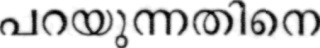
പറയുന്നതിനെ
